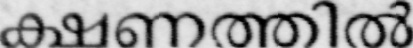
ക്ഷണത്തില്‍
